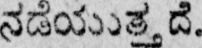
ನಡೆಯುತ್ತದೆ.
